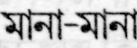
মানা-মানা
